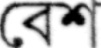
বেশ
